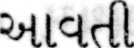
આવતી
